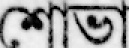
শোভা
